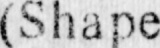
(Shape
